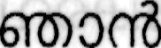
ഞാന്‍
